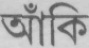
আঁকি
